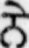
ਨੇ
